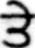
ਤੇ
